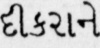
દીકરાને
